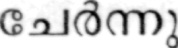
ചേര്‍ന്നു
